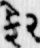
ફેર
